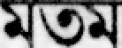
মতম
